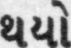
થયો
